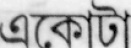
একোটা
